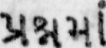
પ્રશ્નમાં
